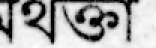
মথক্তা
